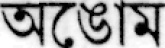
অঙোম
